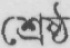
শ্ৰেষ্ঠ
